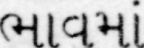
ભાવમાં
